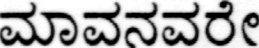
ಮಾವನವರೇ
